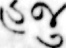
હજુ
